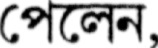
পেলেন,
